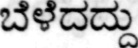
ಬೆಳೆದದ್ದು
